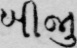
બીજુ
